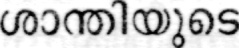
ശാന്തിയുടെ
